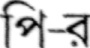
পি-র
